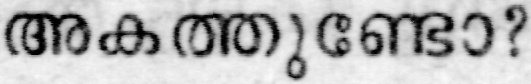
അകത്തുണ്ടോ?
